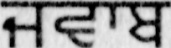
ਜਵਾਬ
